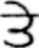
ਤੇ
